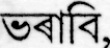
ভৰাবি,
